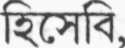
হিসেবি,
